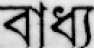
বাধ্য
